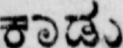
ಕಾಡು
